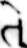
તે
